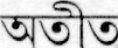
অতীত
